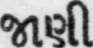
જાણી
